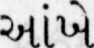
આંખે
